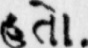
હતો.
